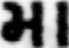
મા
